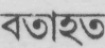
বতাহত
